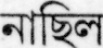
নাছিল
